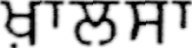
ਖ਼ਾਲਸਾ
